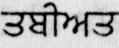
ਤਬੀਅਤ
